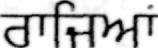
ਰਾਜਿਆਂ
